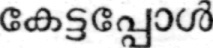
കേട്ടപ്പോള്‍
